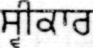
ਸ੍ਵੀਕਾਰ
